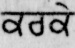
ਕਰਕੇ
